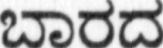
ಬಾರದ
